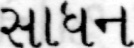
સાધન
